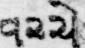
ઘર
